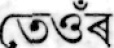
তেওঁৰ
